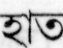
হাত
